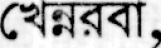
খেন্নরবা,
